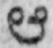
ಆ
